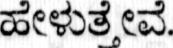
ಹೇಳುತ್ತೇವೆ.
